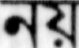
নয়
